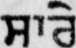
ਸਾਰੇ
